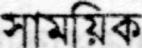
সাময়িক
